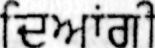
ਦਿਆਂਗੀ
